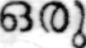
ഒരു
